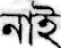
নাই
